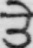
ਤੇ
